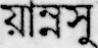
য়াম্নসু
